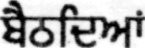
ਬੈਠਦਿਆਂ
